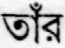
তাঁর
